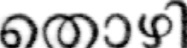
തൊഴി
